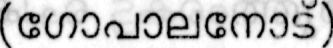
(ഗോപാലനോട്)
